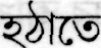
হঠাতে
